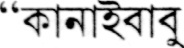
“কানাইবাবু
